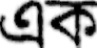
এক
